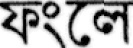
ফংলে
